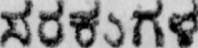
ಸರಕುಗಳ
